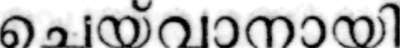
ചെയ്വാനായി
